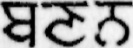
ਬਣਨ
